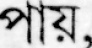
পায়,
